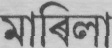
মাৰিলা
